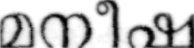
മനീഷ
